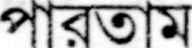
পারতাম
